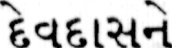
દેવદાસને
